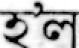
হ'ল
